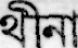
থীনা
